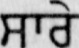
ਸਾਰੇ
